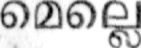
മെല്ലെ
